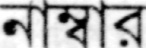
নাম্বার
